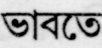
ভাবতে
